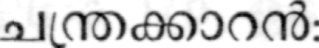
ചന്ത്രക്കാറന്‍:
